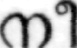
നീ
